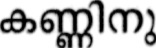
കണ്ണിനു
